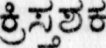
ಕ್ರಿಸ್ತಶಕ
